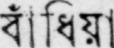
বাঁধিয়া
